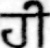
ਹੀ
